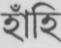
হাঁহি
